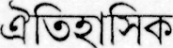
ঐতিহাসিক
